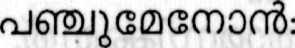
പഞ്ചുമേനോന്‍:
